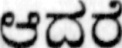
ಆದರೆ
